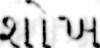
શોખ
